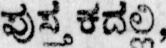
ಪುಸ್ತಕದಲ್ಲಿ,
